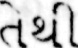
તેથી
